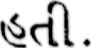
હતી.
